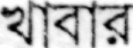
খাবার
